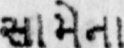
સામેના
